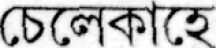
চেলেকাহে
